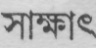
সাক্ষাৎ
